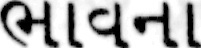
ભાવના
